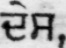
ਦੇਸ,
